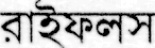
রাইফলস
